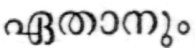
ഏതാനും
